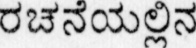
ರಚನೆಯಲ್ಲಿನ
